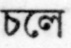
চলে
